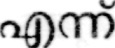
എന്ന്
